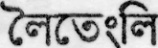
লৈতেংলি
